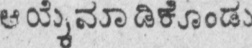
ಆಯ್ಕೆಮಾಡಿಕೊಂಡು
